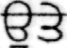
ਉਤੇ
